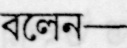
বলেন–
